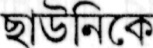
ছাউনিকে
